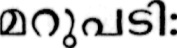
മറുപടി:
